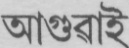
আগুৱাই
